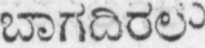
ಬಾಗದಿರಲು
